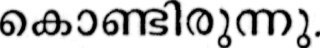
കൊണ്ടിരുന്നു.
